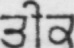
ਤੀਕ
